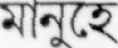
মানুহে
